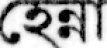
হেন্না
